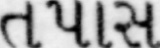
તપાસ
